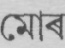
মোৰ
